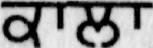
ਕਾਲਾ
